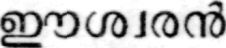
ഈശ്വരന്‍
